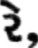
રે,
